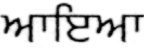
ਆਇਆ
